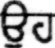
ਉਹ
